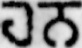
ਹਨ
